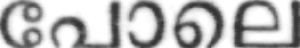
പോലെ
